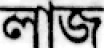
লাজ
